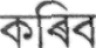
কৰিব
